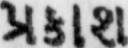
પ્રકાશ
